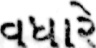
વધારે
